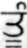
ਤੂੰ
